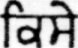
ਕਿਸੇ
